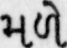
મળે
